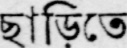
ছাড়িতে
